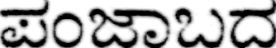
ಪಂಜಾಬದ
